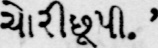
ચોરીછૂપી.'
